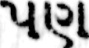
પણ
